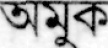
অমুক
